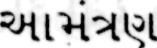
આમંત્રણ
